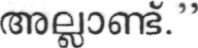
അല്ലാണ്ട്."
